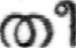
തീ
